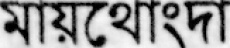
মায়থোংদা
